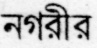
নগরীর
